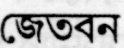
জেতবন
